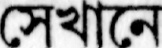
সেখানে
